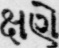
ક્ષણે
